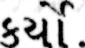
કર્યો.
